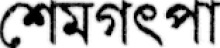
শেমগৎপা
